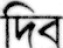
দিব
